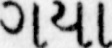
ગયા
